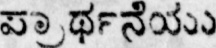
ಪ್ರಾರ್ಥನೆಯು
